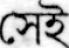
সেই
